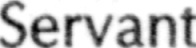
Servant
